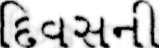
દિવસની
